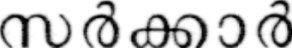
സര്‍ക്കാര്‍
